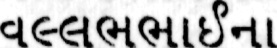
વલ્લભભાઈના
